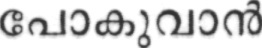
പോകുവാന്‍
